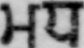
ਮਧ
